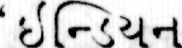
'ઈન્ડિયન
